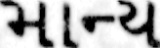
માન્ય
